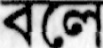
বলে
